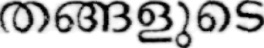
തങ്ങളുടെ
